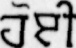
ਹੋਈ
